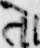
તો
